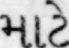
માટે
